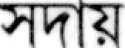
সদায়
